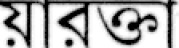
য়ারক্তা
